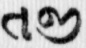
તજી
